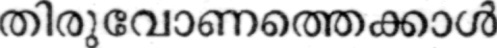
തിരുവോണത്തെക്കാള്‍
